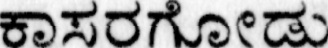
ಕಾಸರಗೋಡು
